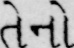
તેનો
